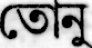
তোনু
